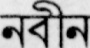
নবীন
